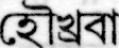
হৌখ্রবা
